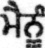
ਮੈਨੂੰ
